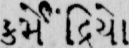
કર્મેદ્રિયો
